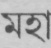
মহা
